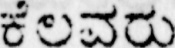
ಕೆಲವರು
